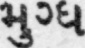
મુગ્ધ
